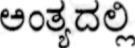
ಅಂತ್ಯದಲ್ಲಿ
